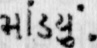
માંડ્યું.
